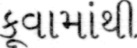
કૂવામાંથી
